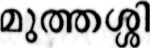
മുത്തശ്ശി
